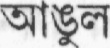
আঙুল
